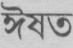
ঈষত
